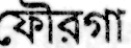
ফৌরগা
